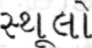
સ્થૂલો
